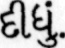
દીધું.
